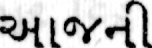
આજની
